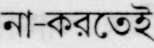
না-করতেই
